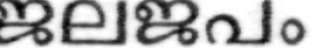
ജലജപം
